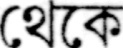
থেকে
